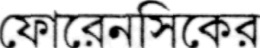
ফোরেনসিকের
